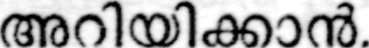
അറിയിക്കാന്‍.
